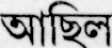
আছিল
